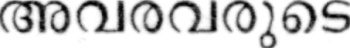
അവരവരുടെ
